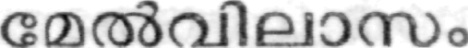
മേല്‍വിലാസം
